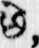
છે,
